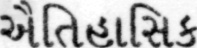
ઐતિહાસિક
